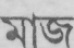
মাজ
